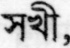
সখী,
